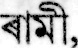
ৰামী,
